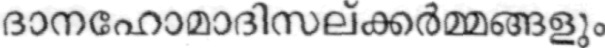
ദാനഹോമാദിസല്ക്കര്‍മ്മങ്ങളും
